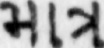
માત્ર
